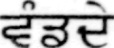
ਵੰਡਦੇ
